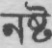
নষ্ট
